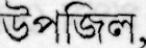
উপজিল,
